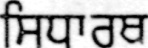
ਸਿਧਾਰਥ
